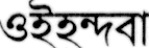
ওইহন্দবা
